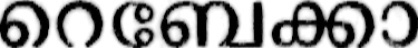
റെബേക്കാ
